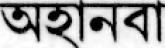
অহানবা
